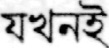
যখনই
